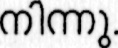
നിന്നു.
